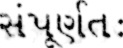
સંપૂર્ણતઃ
